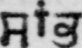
ਸਾਂਭ
